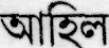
আহিল
